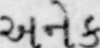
અનેક
